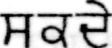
ਸਕਦੇ
